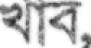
খাব,
